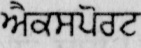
ਐਕਸਪੋਰਟ
